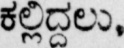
ಕಲ್ಲಿದ್ದಲು,
